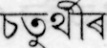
চতুৰ্থীৰ
